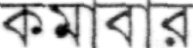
কমাবার
